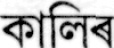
কালিৰ
